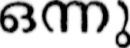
ഒന്നു
